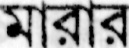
মারার
